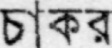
চাকর
